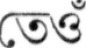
তেওঁ
